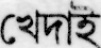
খেদাই
